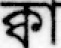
ক্বা
